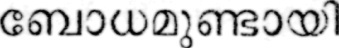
ബോധമുണ്ടായി
